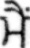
ਮੈਂ
